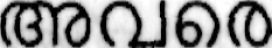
അവരെ
